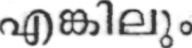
എങ്കിലും
